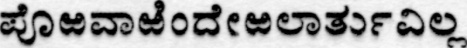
ಪೊಱವಾಱಿಂದೇಱಲಾರ್ತುವಿಲ್ಲ
